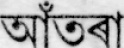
আঁতৰা
